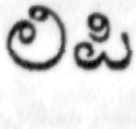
ಲಿಪಿ
